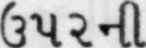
ઉપરની
